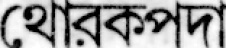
থোরকপদা
